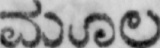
ಮೂಲ
